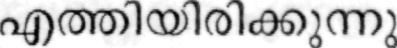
എത്തിയിരിക്കുന്നു
